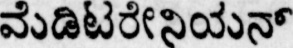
ಮೆಡಿಟರೇನಿಯನ್
